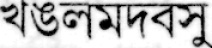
খঙলমদবসু
